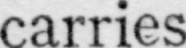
carries
